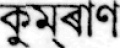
কুম্‌ৰাণ
